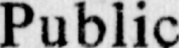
Public
